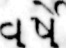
વર્ષે
